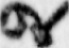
જ
